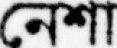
নেশা
